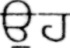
ਉਹ
